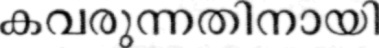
കവരുന്നതിനായി
